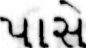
પાસે
